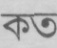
কত
